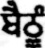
ਬੈਠੂੰ
